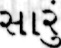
સારું
